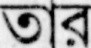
তার
